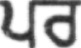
ਪਰ
